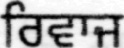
ਰਿਵਾਜ
